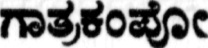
ಗಾತ್ರಕಂಪೋ
